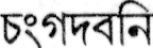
চংগদবনি
